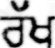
ਰੱਖ
